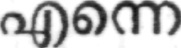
എന്നെ
